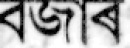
বজাৰ
